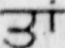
ਤਾਂ
